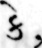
કે,
